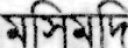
মসিমদি
